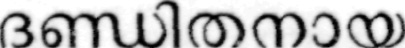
ദണ്ഡിതനായ
